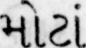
મોટાં
